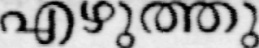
എഴുത്തു
